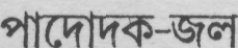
পাদোদক-জল
